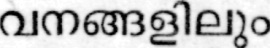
വനങ്ങളിലും
